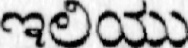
ಇಲಯು
